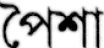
পৈশা
